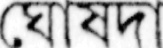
ঘোষদা
